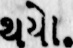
થયો.
